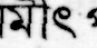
মমীৎ
